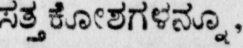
ಸತ್ತಕೋಶಗಳನ್ನೂ,
